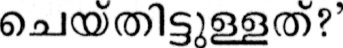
ചെയ്തിട്ടുള്ളത്?’
